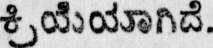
ಕ್ರಿಯೆಯಾಗಿದೆ.
